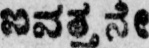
ಐವತ್ತನೇ
